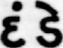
દંડે
